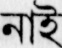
নাই
